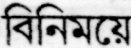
বিনিময়ে
